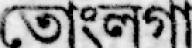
তোংলগা
